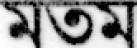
মতম
